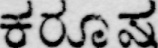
ಕರೂಷ
